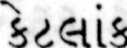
કેટલાંક
